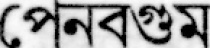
পেনবগুম
